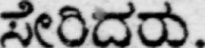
ಸೇರಿದರು.
